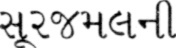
સૂરજમલની
